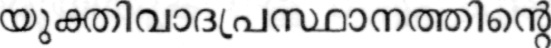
യുക്തിവാദപ്രസ്ഥാനത്തിന്റെ
